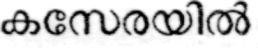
കസേരയില്‍
